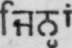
ਜਿਨ੍ਹਾਂ
